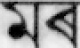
মৰ
